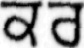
ਕਰ
